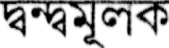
দ্বন্দ্বমূলক
